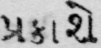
પ્રકાશે
